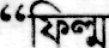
“ফিল্ম
